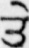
ਤੇ
